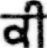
ਕੀ
